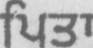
ਪਿਤਾ
